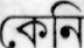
কেনি
